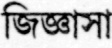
জিজ্ঞাসা
